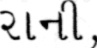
રાની,
